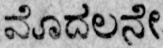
ಮೊದಲನೇ
